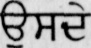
ਉਸਦੇ
